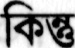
কিন্তু
